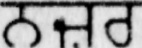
ਨਜ਼ਰ
